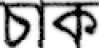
চাক
